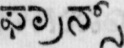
ಫ್ರಾನ್ಸ್
